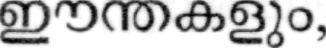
ഈന്തകളും,
